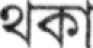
থকা
